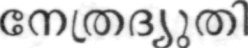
നേത്രദ്യുതി
